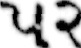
પર
